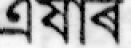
এষাৰ
